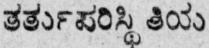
ತರ್ತುಪರಿಸ್ಥಿತಿಯ
